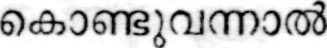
കൊണ്ടുവന്നാല്‍
